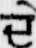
ਦੇ
